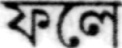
ফলে
